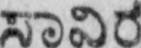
ಸಾವಿರ
